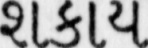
શકાય
